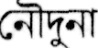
নৌদুনা
